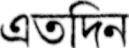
এতদিন
